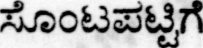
ಸೊಂಟಪಟ್ಟಿಗೆ
